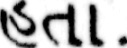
હતા.
